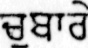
ਚੁਬਾਰੇ
